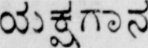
ಯಕ್ಷಗಾನ
